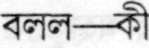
বলল–কী
